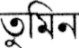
তুমিন
